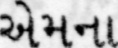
એમના
